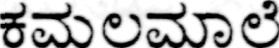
ಕಮಲಮಾಲೆ
